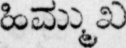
ಹಿಮ್ಮುಖ
